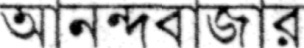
আনন্দবাজার
